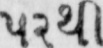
પરથી
